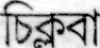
চিক্লবা
